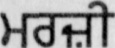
ਮਰਜ਼ੀ
